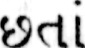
છતાં
